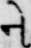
ને
